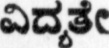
ವಿದ್ಯತೇ
